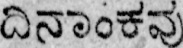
ದಿನಾಂಕವು
